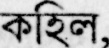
কহিল,
